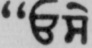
''ਓਸੇ
